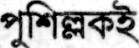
পুশিল্লকই
